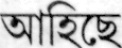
আহিছে
